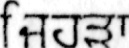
ਜਿਹੜਾ
